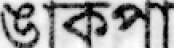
ঙাকপা
